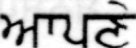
ਆਪਣੇ
